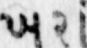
ખરાં
